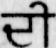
ਦੀ
